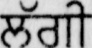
ਲੱਗੀ
